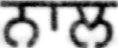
ਨਾਲ
